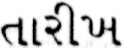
તારીખ
